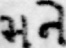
મને
